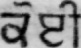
ਕੋਈ
